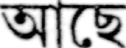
আছে
